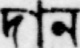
দান
